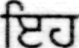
ਇਹ
